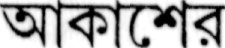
আকাশের
